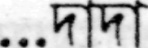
...দাদা
